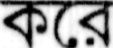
করে
